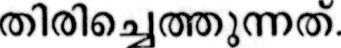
തിരിച്ചെത്തുന്നത്.
